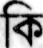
কি
